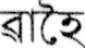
ৱাহৈ
